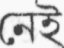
নেই
